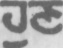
ਹੁਣ
